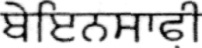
ਬੇਇਨਸਾਫ਼ੀ
